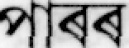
পাৰৰ
